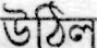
উঠিল
